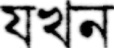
যখন
